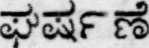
ಘರ್ಷಣೆ
